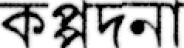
কপ্পদনা
